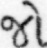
જો
